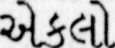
એકલો
